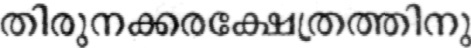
തിരുനക്കരക്ഷേത്രത്തിനു
